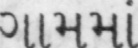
ગામમાં
